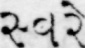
સ્વરે
